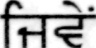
ਜਿਵੇਂ
